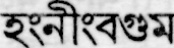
হংনীংবগুম
